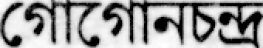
গোগোনচন্দ্র
